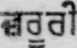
ਜ਼ਰੂਰੀ
